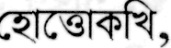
হোত্তোকখি,
